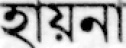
হায়না
